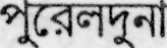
পুরেলদুনা
